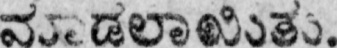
ಮಾಡಲಾಯಿತು.
